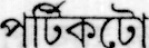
পৰ্টিকটো
